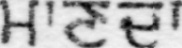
ਮਾਣਦਾ
